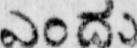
ಎಂದು
